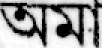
অমা
